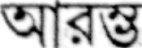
আরম্ভ
